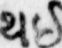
થઈ
